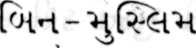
બિન-મુસ્લિમ
